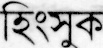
হিংসুক
